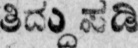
ತಿದ್ದುಪಡಿ
